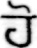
ਹੋ
